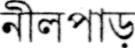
নীলপাড়
